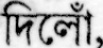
দিলোঁ,
